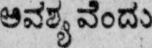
ಅವಶ್ಯವೆಂದು
